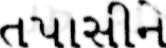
તપાસીને
